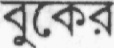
বুকের
